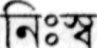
নিঃস্ব
